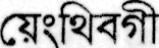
য়েংথিবগী
